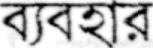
ব্যবহার
